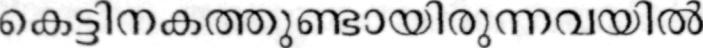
കെട്ടിനകത്തുണ്ടായിരുന്നവയില്‍
